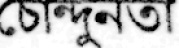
চোন্দুনতা
